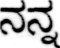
ನನ್ನ
